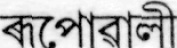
ৰূপোৱালী
